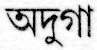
অদুগা
